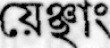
য়েঞ্ছাং
